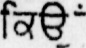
ਕਿਉਂ
